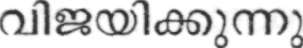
വിജയിക്കുന്നു
